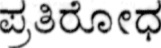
ಪ್ರತಿರೋಧ
